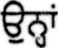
ਉਨ੍ਹਾਂ
